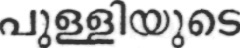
പുള്ളിയുടെ
